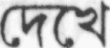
দেখে
